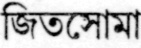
জিতসোমা
